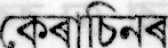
কেৰাচিনৰ
